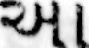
આ
